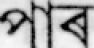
পাৰ
